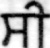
ਸੀ
